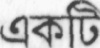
একটি
